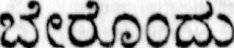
ಬೇರೊಂದು
